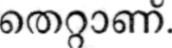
തെറ്റാണ്.
